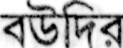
বউদির
